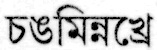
চঙমিন্নখ্রে
